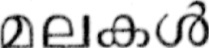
മലകള്‍
